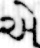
એ
